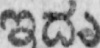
ಇದು
